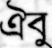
ঐবু
